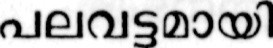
പലവട്ടമായി
